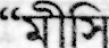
“মীসি
